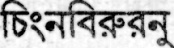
চিংনবিরুরনু
